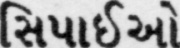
સિપાઈઓ
